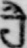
ਹੈ
